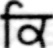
ਕਿ
